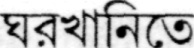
ঘরখানিতে
